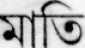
মাতি
